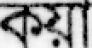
কয়া
